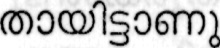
തായിട്ടാണു
